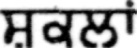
ਸ਼ਕਲਾਂ
